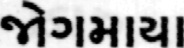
જોગમાયા
